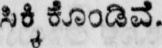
ಸಿಕ್ಕಿಕೊಂಡಿವೆ.
